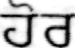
ਹੋਰ
